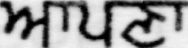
ਆਪਣਾ
